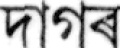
দাগৰ
